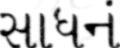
સાધનં
